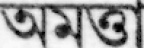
অমত্তা
